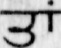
ਤਾਂ
